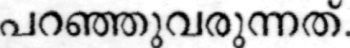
പറഞ്ഞുവരുന്നത്.
